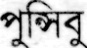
পুন্সিবু
